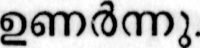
ഉണര്‍ന്നു.
